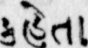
કહેતા
